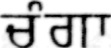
ਚੰਗਾ
